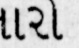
તારો
